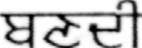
ਬਣਦੀ
